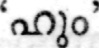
'ഹും'
